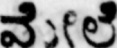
ಮೇಲೆ
